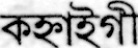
কহ্নাইগী
